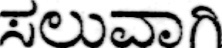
ಸಲುವಾಗಿ
